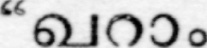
"ഖറാം
